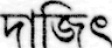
দাজিৎ
